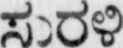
ಸುರಳಿ
